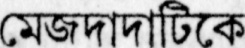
মেজদাদাটিকে
